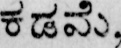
ಕಡಮೆ,
